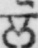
ਲੋ
